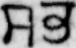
ਸਭ
